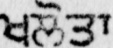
ਖਲੋਤਾ
